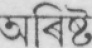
অৰিষ্ট
